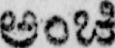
ಅಂಚಿ
